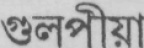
গুলপীয়া
